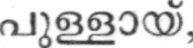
പുള്ളായ്,
